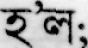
হ'ল;
